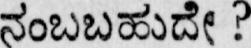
ನಂಬಬಹುದೇ?
